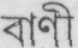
বাণী
